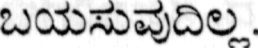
ಬಯಸುವುದಿಲ್ಲ.
